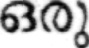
ഒരു
